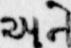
અને
